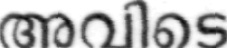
അവിടെ
